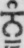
ਨੂੰ
